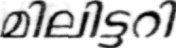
മിലിട്ടറി
